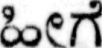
ಹೀಗೆ
